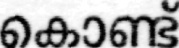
കൊണ്ട്
